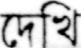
দেখি
